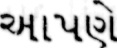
આપણે
